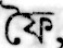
ফৈ,
